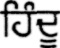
ਹਿੰਦੂ
